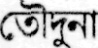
তৌদুনা
